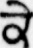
ਕੇ
